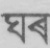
ঘৰ
